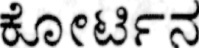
ಕೋರ್ಟಿನ
